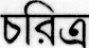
চরিত্র
